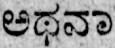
ಅಥವಾ
